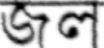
জল
